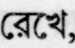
রেখে,
